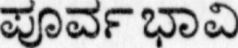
ಪೂರ್ವಭಾವಿ
